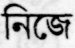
নিজে
